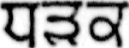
ਧੜਕ
